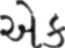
એક
